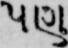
પણ
